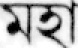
মহা
